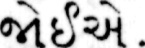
જોઈએ.
